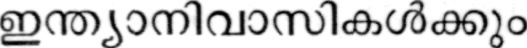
ഇന്ത്യാനിവാസികള്‍ക്കും
